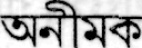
অনীমক
